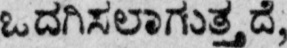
ಒದಗಿಸಲಾಗುತ್ತದೆ,
